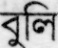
বুলি
